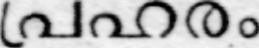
പ്രഹരം
